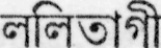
ললিতাগী
